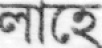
লাহে
